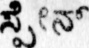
ಸ್ಪೇನ್
